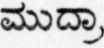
ಮುದ್ರಾ
